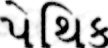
પેથિક
